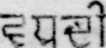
ਵਧਦੀ
